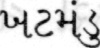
ખટમંડુ
